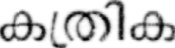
കത്രിക
